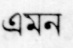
এমন
